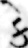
કે
